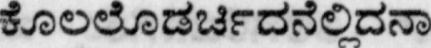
ಕೊಲಲೊಡರ್ಚಿದನೆಲ್ಲಿದನಾ
